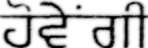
ਹੋਵੇਂਗੀ
